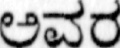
ಅವರ
